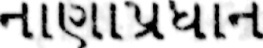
નાણાપ્રધાન
